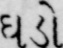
ઘડો
